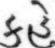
કહે
